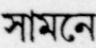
সামনে
